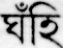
ঘঁহি
